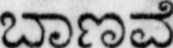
ಬಾಣವೆ
